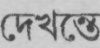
দেখন্তে
